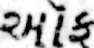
ઑફ
